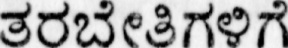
ತರಬೇತಿಗಳಿಗೆ
